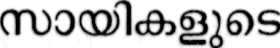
സായികളുടെ
